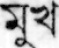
মুখ
